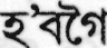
হ'বগৈ
